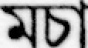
মচা
